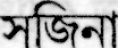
সজিনা
